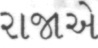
રાજાએ
